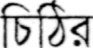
চিঠির
